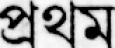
প্রথম
